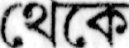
থেকে
